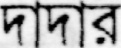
দাদার
